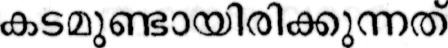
കടമുണ്ടായിരിക്കുന്നത്
